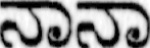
ನಾನಾ
